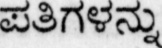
ಪತಿಗಳನ್ನು
